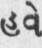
હવે
